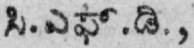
ಸಿ.ಎಫ್.ಡಿ.,
